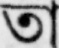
তা
